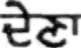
ਦੇਣਾ
